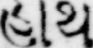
હાથ
